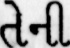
તેની
